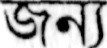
জন্য
